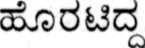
ಹೊರಟಿದ್ದ
